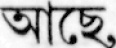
আছে,
